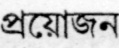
প্রয়োজন
